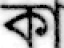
কা
